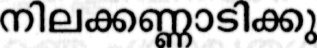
നിലക്കണ്ണാടിക്കു
